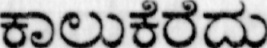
ಕಾಲುಕೆರೆದು
